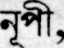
নূপী,
